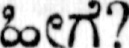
ಹೀಗೆ?
